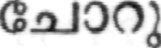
ചോറു
